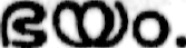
ഭയം.
